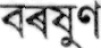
বৰষুণ
